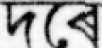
দৰে
